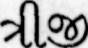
ત્રીજી
